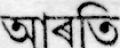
আৰতি
